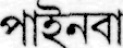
পাইনবা
